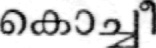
കൊച്ചീ
